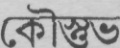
কৌস্তুভ
